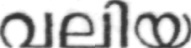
വലിയ
